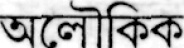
অলৌকিক
